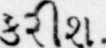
કરીશ.
